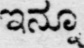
ಇನ್ನೂ
